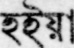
হইয়া
